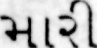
મારી
